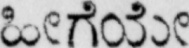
ಹೀಗೆಯೇ
